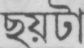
ছয়টা
